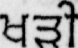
ਖੜੀ
